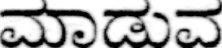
ಮಾಡುವ
